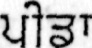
ਪੀਡਾ
